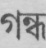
গন্ধ
